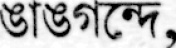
ঙাঙগন্দে,
